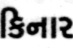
કિનાર
